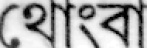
থোংবা
